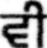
ਵੀ
